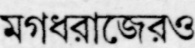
মগধরাজেরও
